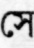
সে
